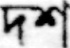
দশ
